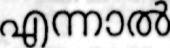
എന്നാല്‍
